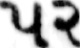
પર
